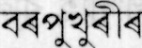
বৰপুখুৰীৰ
